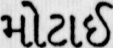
મોટાઈ
